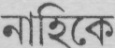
নাহিকে
